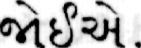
જોઇએ.
